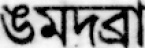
ঙমদব্রা
